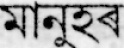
মানুহৰ
